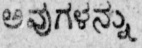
ಅವುಗಳನ್ನು
